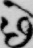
છે
